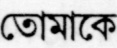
তোমাকে
